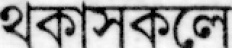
থকাসকলে
